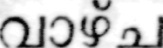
വാഴ്ച
